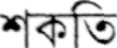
শকতি
